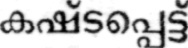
കഷ്ടപ്പെട്ട്
